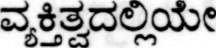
ವ್ಯಕ್ತಿತ್ವದಲ್ಲಿಯೇ
